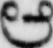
ಆ
